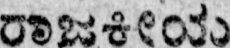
ರಾಜಕೀಯ
